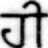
ਹੀ
